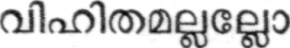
വിഹിതമല്ലല്ലോ
